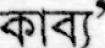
কাব্য’
